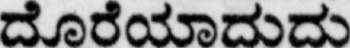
ದೊರೆಯಾದುದು
